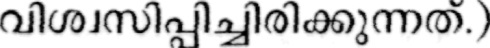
വിശ്വസിപ്പിച്ചിരിക്കുന്നത്.)
